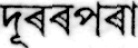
দূৰৰপৰা
